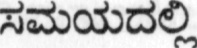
ಸಮಯದಲ್ಲಿ
